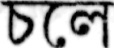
চলে
